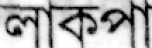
লাকপা
